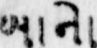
બાનો
